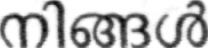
നിങ്ങള്‍
